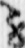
કે
